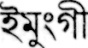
ইমুংগী
